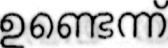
ഉണ്ടെന്ന്
